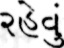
રહેવું
